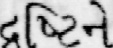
દ્રષ્ટિને
